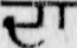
ਦਾ
